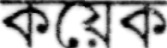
কয়েক
